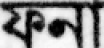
ফনা
